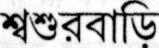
শ্বশুরবাড়ি
